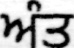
ਅੰਤ
